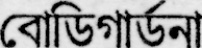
বোডিগার্ডনা
